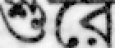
শুরে
